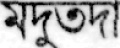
মদুতদা
